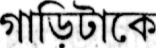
গাড়িটাকে
